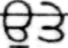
ਉਤੇ
